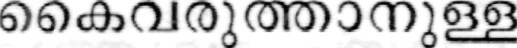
കൈവരുത്താനുള്ള
